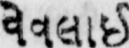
વેવલાઈ
